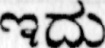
ಇದು
